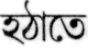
হঠাতে
